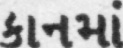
કાનમાં
